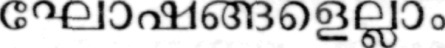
ഘോഷങ്ങളെല്ലാം
